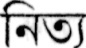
নিত্য
